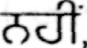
ਨਹੀਂ,
